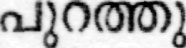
പുറത്തു
